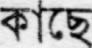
কাছে
